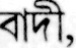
বাদী,
